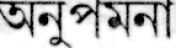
অনুপমনা
